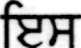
ਇਸ
